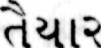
તૈયાર
